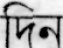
দিন
